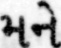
મને
